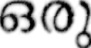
ഒരു
